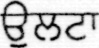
ਉਲਟਾ
